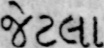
જેટલા
